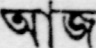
আজ
